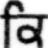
ਕਿ
